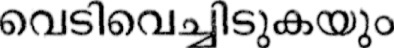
വെടിവെച്ചിടുകയും
